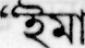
“ইমা
